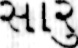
સારુ
